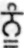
ਨੂੰ
